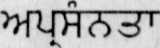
ਅਪ੍ਰਸੰਨਤਾ
